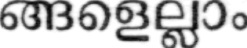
ങ്ങളെല്ലാം
